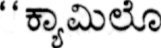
"ಕ್ಯಾಮಿಲೊ
